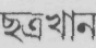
ছত্রখান
